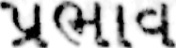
પ્રભાવ
